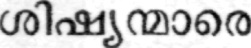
ശിഷ്യന്മാരെ
